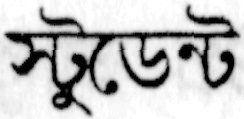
স্টুডেন্ট
